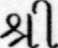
શ્રી
